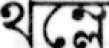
থম্লে
